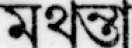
মথন্তা
